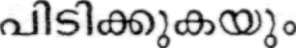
പിടിക്കുകയും
